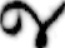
જ
